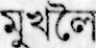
মুখলৈ
